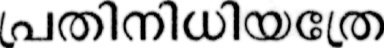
പ്രതിനിധിയത്രേ
